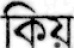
কিয়
